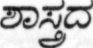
ಶಾಸ್ತ್ರದ
